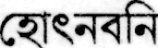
হোৎনবনি
